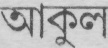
আকুল
